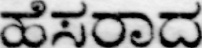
ಹೆಸರಾದ
